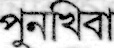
পুনখিবা
